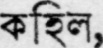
কহিল,
